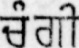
ਚੰਗੀ
